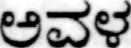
ಅವಳ
